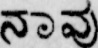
ನಾವು
